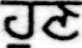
ਹੁਣ
